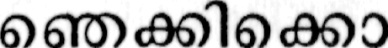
ഞെക്കിക്കൊ
